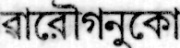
ৱারৌগনুকো
